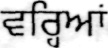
ਵਰ੍ਹਿਆਂ
